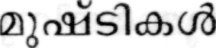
മുഷ്ടികള്‍
